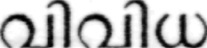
വിവിധ
